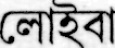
লোইবা
